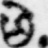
છે.
